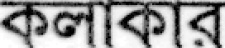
কলাকার
